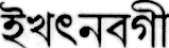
ইখৎনবগী
